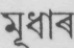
মূধাৰ
